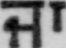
ਜਾ
